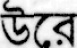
উরে
